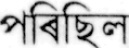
পৰিছিল
